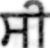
ਸੀ
